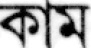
কাম
